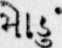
મોડું
